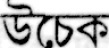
উচেক
